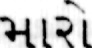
મારો
